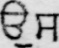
ਉਸ
